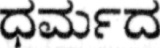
ಧರ್ಮದ
